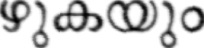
ഴുകയും
